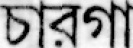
চারগা
